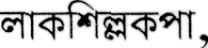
লাকশিল্লকপা,
